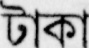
টাকা
